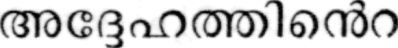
അദ്ദേഹത്തിന്റെ
